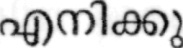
എനിക്കു
